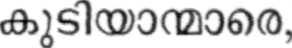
കുടിയാന്മാരെ,
